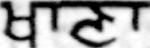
ਖਾਣਾ
